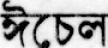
ঈচেল
